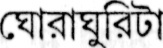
ঘোরাঘুরিটা
